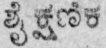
ಶೈಕ್ಷಣಿಕ
